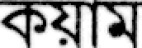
কয়াম
